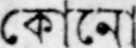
কোনো
